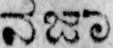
ವಜಾ
